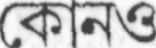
কোনও
